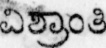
ವಿಶ್ರಾಂತಿ
